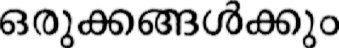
ഒരുക്കങ്ങള്‍ക്കും
